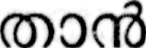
താന്‍
